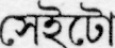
সেইটো
